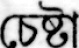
চেষ্টা
